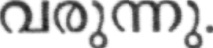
വരുന്നു.
